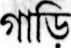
গাড়ি
